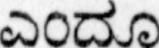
ಎಂದೂ
